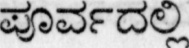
ಪೂರ್ವದಲ್ಲಿ
